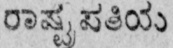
ರಾಷ್ಟ್ರಪತಿಯ
